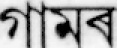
গামৰ
